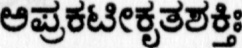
ಅಪ್ರಕಟೀಕೃತಶಕ್ತಿಃ
